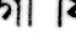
ঐগী
